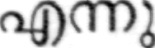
എന്നു
